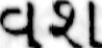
વશ
